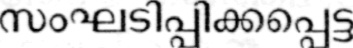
സംഘടിപ്പിക്കപ്പെട്ട
